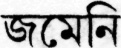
জমেনি
